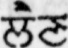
ਲੈਣ
